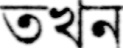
তখন
